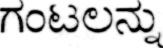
ಗಂಟಲನ್ನು
